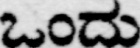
ಒ೦ದು
